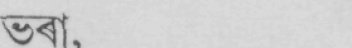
ভৰা,
